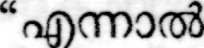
“എന്നാല്‍
